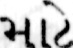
માટે
